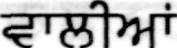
ਵਾਲੀਆਂ
